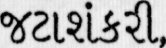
જટાશંકરી,
